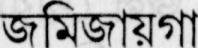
জমিজায়গা
